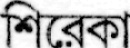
শিরেগা
